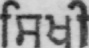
ਸਿਖੀ
